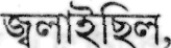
জ্বলাইছিল,
